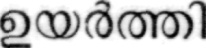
ഉയര്‍ത്തി
